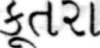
કૂતરા
